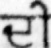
ਦੀ
